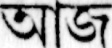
আজ
